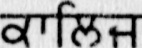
ਕਾਲਿਜ
